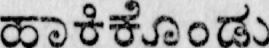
ಹಾಕಿಕೊಂಡು
